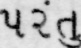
પરંતુ
